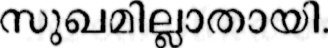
സുഖമില്ലാതായി.
